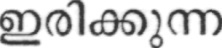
ഇരിക്കുന്ന
